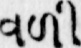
વળી
